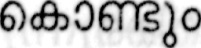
കൊണ്ടും
